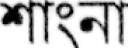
শাংনা
